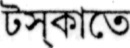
টস্কাতে
